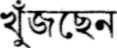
খুঁজছেন
